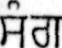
ਸੰਗ
